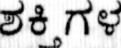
ಶಕ್ತಿಗಳ
